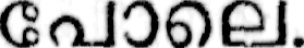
പോലെ.
